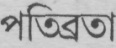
পতিব্ৰতা
